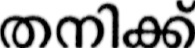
തനിക്ക്
